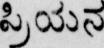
ಪ್ರಿಯನ
